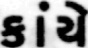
કાંયે
